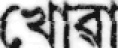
খোৱা
